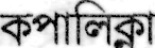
কপালিক্না
